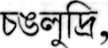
চঙলুদ্রি,
